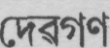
দেৱগণ
